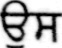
ਉਸ
